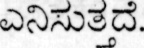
ಎನಿಸುತ್ತದೆ.
